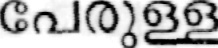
പേരുള്ള
